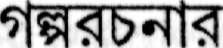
গল্পরচনার
